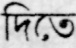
দিতে
